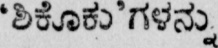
‘ಶಿಕೊಕು’ಗಳನ್ನು
